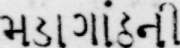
મડાગાંઠની
